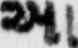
આ
